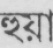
হুয়া
